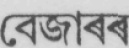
বেজাৰৰ
